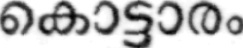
കൊട്ടാരം
